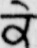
ਕੇ
